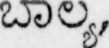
ಬಾಲ್ಯ,
